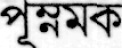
পূম্নমক
